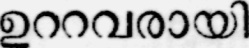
ഉററവരായി
